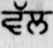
ਵੱਲ
